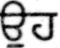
ਉਹ
